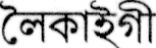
লৈকাইগী
